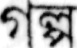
গল্প
